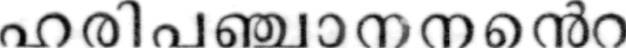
ഹരിപഞ്ചാനനന്റെ
